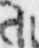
તો
